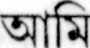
আমি
